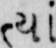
ત્યાં
